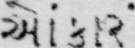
ઓંકારં
